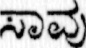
ಸಾವು
